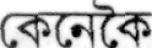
কেনেকৈ
